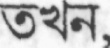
তখন,
